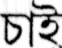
চাই
